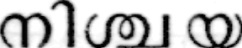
നിശ്ചയ
